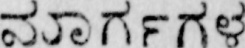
ಮಾರ್ಗಗಳ
